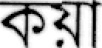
কয়া
